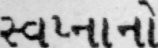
સ્વપ્નાનો
